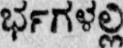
ರ್ಭಗಳಲ್ಲಿ
